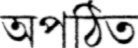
অপঠিত
